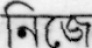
নিজে
